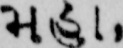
મહા,
